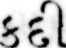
કદી
